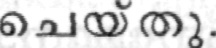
ചെയ്തു.
